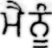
ਮੈਨੂੰ
